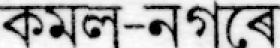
কমল-নগৰে
